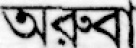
অরুবা
